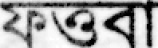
ফত্তবা
